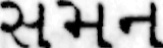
સમન
